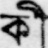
কী
